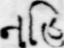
નહિ
